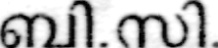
ബി.സി.
